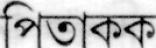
পিতাকক
